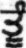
ਤੂੰ
